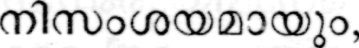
നിസംശയമായും,
